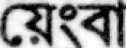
য়েংবা
